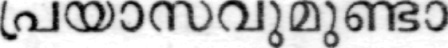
പ്രയാസവുമുണ്ടാ
